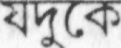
যদুকে
